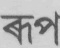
ৰূপ
